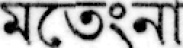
মতেংনা
